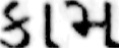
કામ
